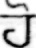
ਹੋ
